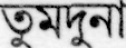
তুমদুনা
